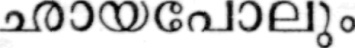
ഛായപോലും
